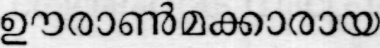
ഊരാണ്‍മക്കാരായ
